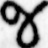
જ
